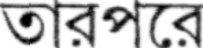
তারপরে
